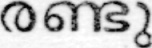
രണ്ടു
